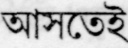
আসতেই
